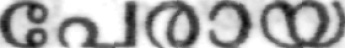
പേരായ
